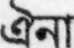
ঐনা
